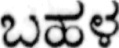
ಬಹಳ
